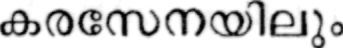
കരസേനയിലും
